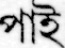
পাই
